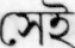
সেই
